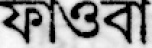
ফাওবা
